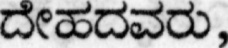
ದೇಹದವರು,
